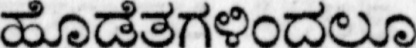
ಹೊಡೆತಗಳಿಂದಲೂ
